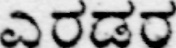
ಎರಡರ
